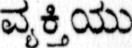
ವ್ಯಕ್ತಿಯು
